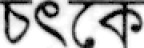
চৎকে
